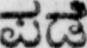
ಪಡೆ
